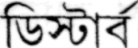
ডিস্টার্ব
